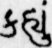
કહ્યું,
